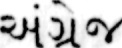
અંગ્રેજ
